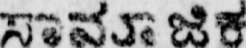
ಸಾಮಾಜಿಕ
